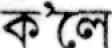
ক'লে
